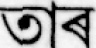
তাৰ
